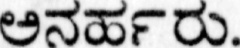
ಅನರ್ಹರು.
